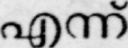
എന്ന്
